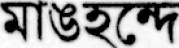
মাঙহন্দে
